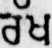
ਰੱਖ
